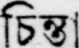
চিন্তা
